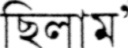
ছিলাম’
